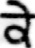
ਕੇ
